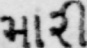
મારી
